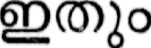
ഇതും
